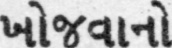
ખોજવાનો
